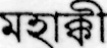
মহাক্কী
